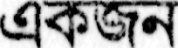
একজন
